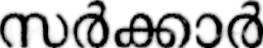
സര്‍ക്കാര്‍
